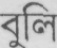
বুলি
